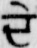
ਦੇ
